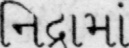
નિદ્રામાં
